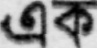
এক
